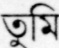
তুমি
